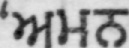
'ਅਮਨ
